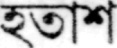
হতাশ
